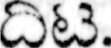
ದಿಟ.
